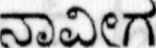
ನಾವೀಗ
